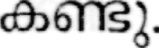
കണ്ടു.
